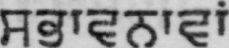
ਸਭਾਵਨਾਵਾਂ
